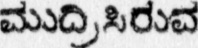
ಮುದ್ರಿಸಿರುವ
